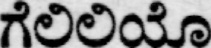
ಗೆಲಿಲಿಯೊ
